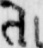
તો
